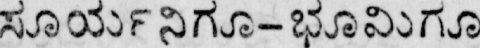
ಸೂರ್ಯನಿಗೂ-ಭೂಮಿಗೂ
